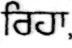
ਰਿਹਾ,
